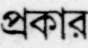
প্রকার
